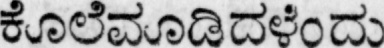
ಕೊಲೆಮಾಡಿದಳೆಂದು
